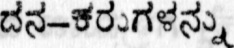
ದನ-ಕರುಗಳನ್ನು
